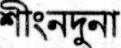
শীংনদুনা
